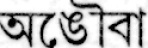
অঙৌবা
